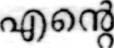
എന്റെ
